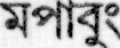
মপাবুং
